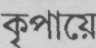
কৃপায়ে
